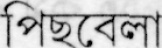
পিছবেলা
